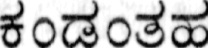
ಕಂಡಂತಹ
